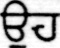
ਉਹ
